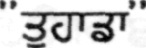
''ਤੁਹਾਡਾ''
